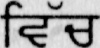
ਵਿੱਚ
